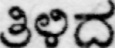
ತಿಳಿದ
